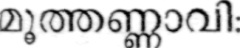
മൂത്തണ്ണാവി:
